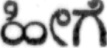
ಹೀಗೆ
